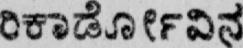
ರಿಕಾರ್ಡೋವಿನ
